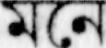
মনে
